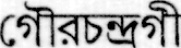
গৌরচন্দ্রগী
